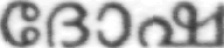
ദോഷ
